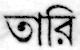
তারি
